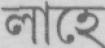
লাহে
